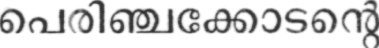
പെരിഞ്ചക്കോടന്റെ
